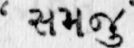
'સમજું
